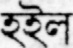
হইল
